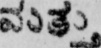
ಮತ್ತು
